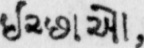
ઇચ્છાઓ,
